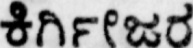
ಕಿರ್ಗೀಜರ
